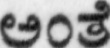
ಅಂತೆ
